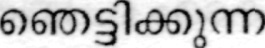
ഞെട്ടിക്കുന്ന
